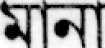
মানা
